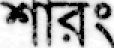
শারং
